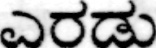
ಎರಡು
